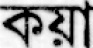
কয়া
